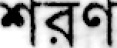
শরণ
